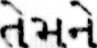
તેમને
